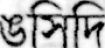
ঙসিদি
